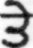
ਤੇ
